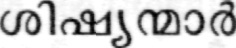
ശിഷ്യന്മാര്‍
